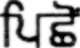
ਪਿਛੋਂ
